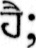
ਹੈ;
